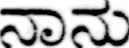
ನಾನು
